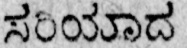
ಸರಿಯಾದ
